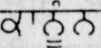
ਕਾਨੂੰਨ
